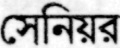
সেনিয়র
